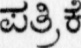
ಪತ್ರಿಕೆ
